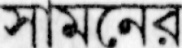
সামনের
